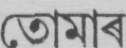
তোমাৰ
